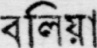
বলিয়া
